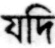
যদি
